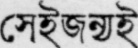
সেইজন্যই
